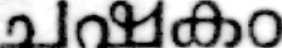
ചഷകം
